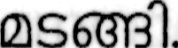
മടങ്ങി.
